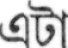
এটা
